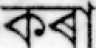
কৰা
